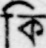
কি
